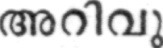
അറിവു
